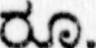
ರೂ.
